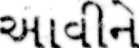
આવીને
